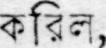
করিল,
